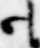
ન
